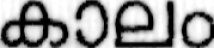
കാലം
